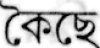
কৈছে
